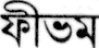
ফীভম
